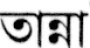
তান্না
